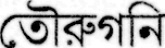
তৌরুগনি
